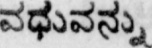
ವಧುವನ್ನು
